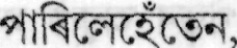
পাৰিলেহেঁতেন,
